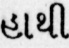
હાથી
